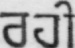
ਰਹੀ
